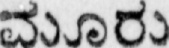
ಮೂರು
